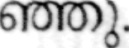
ഞ്ഞു.
